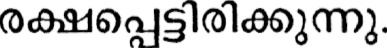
രക്ഷപ്പെട്ടിരിക്കുന്നു.
